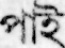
পাই
